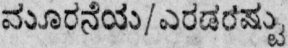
ಮೂರನೆಯ/ಎರಡರಷ್ಟು
